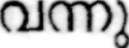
വന്നു
